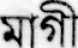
মাগী
